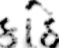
કાંઠે
